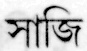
সাজি
